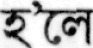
হ'লে
